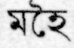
মহৈ
